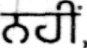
ਨਹੀਂ,
